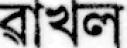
ৱাখল
